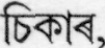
চিকাৰ,
